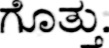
ಗೊತ್ತು.
